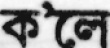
ক'লে
